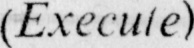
(Execule)
